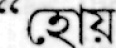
“হোয়
